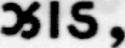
ઝાડ,
